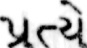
પ્રત્યે
